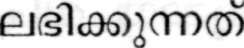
ലഭിക്കുന്നത്
